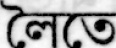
লৈতে
